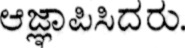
ಆಜ್ಞಾಪಿಸಿದರು.
